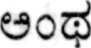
ಅಂಥ
